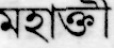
মহাক্তী
